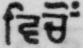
ਵਿਚੋਂ
